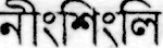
নীংশিংলি
